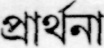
প্রার্থনা
